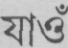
যাওঁ
